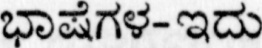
ಭಾಷೆಗಳ-ಇದು
